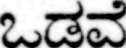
ಒಡವೆ
